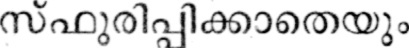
സ്ഫുരിപ്പിക്കാതെയും
